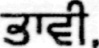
ਭਾਵੀ,
